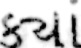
ક્યાં
